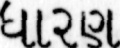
ધારણ
